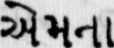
એમના
